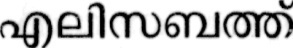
എലിസബത്ത്
